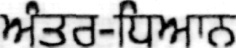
ਅੰਤਰ-ਧਿਆਨ
